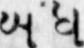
બંધ
